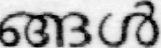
ങ്ങള്‍
